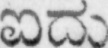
ಐದು
